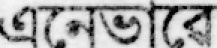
এনেভাৱে
